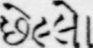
છેલ્લો
